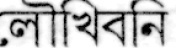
লৌখিবনি
